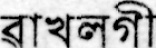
ৱাখলগী
